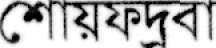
শোয়ফদ্রবা
